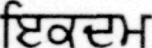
ਇਕਦਮ
